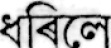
ধৰিলে
